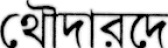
থৌদারদে
